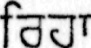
ਰਿਹਾ
